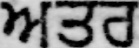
ਅਤਰ
